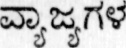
ವ್ಯಾಜ್ಯಗಳ
